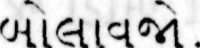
બોલાવજો.
